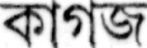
কাগজ
